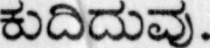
ಕುದಿದುವು.
